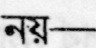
নয়–
